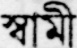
স্বামী
